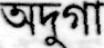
অদুগা
